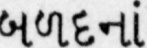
બળદનાં
